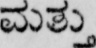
ಮತ್ತು
